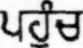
ਪਹੁੰਚ
